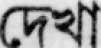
দেখা
